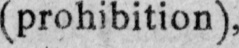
(Prohibition),
